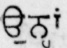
ਉਨ੍ਹਾਂ
